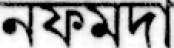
নফমদা
